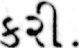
કરી.
